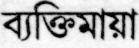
ব্যক্তিমায়া
